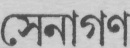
সেনাগণ
